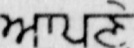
ਆਪਣੇ
